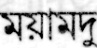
ময়ামদু
